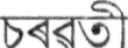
চৰৱতী
